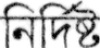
নিৰ্দিষ্ট
